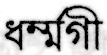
ধর্ম্মগী
